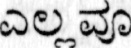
ಎಲ್ಲವೂ
